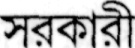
সরকারী
